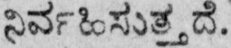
ನಿರ್ವಹಿಸುತ್ತದೆ.
